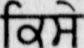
ਕਿਸੇ
